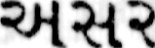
અસર
